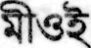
মীওই
